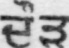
ਦੌੜ
